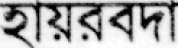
হায়রবদা
